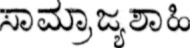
ಸಾಮ್ರಾಜ್ಯಶಾಹಿ
